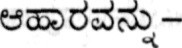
ಆಹಾರವನ್ನು-
